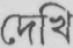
দেখি
